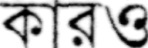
কারও
